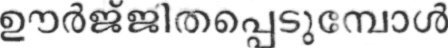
ഊര്‍ജ്ജിതപ്പെടുമ്പോള്‍
